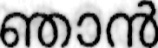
ഞാന്‍
